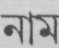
নাম
